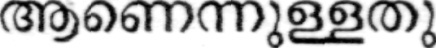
ആണെന്നുള്ളതു
